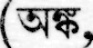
(অঙ্ক,
